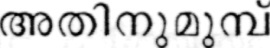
അതിനുമുമ്പ്
